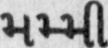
મમ્મી
